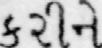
કરીને
